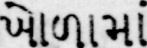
ખોળામાં
